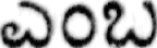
ಎಂಬ
